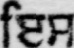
ਇਸ
